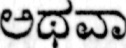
ಅಥವಾ
